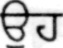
ਉਹ
